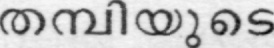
തമ്പിയുടെ
